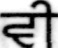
ਵੀ
